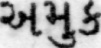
અમુક
